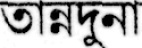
তান্নদুনা
